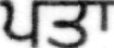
ਪਤਾ
